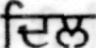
ਦਿਲ
